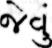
જેવું
